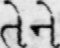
તેને
